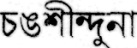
চঙশীন্দুনা
